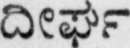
ದೀರ್ಘ
